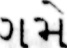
ગમે
